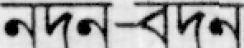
নদন-বদন
